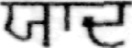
ਯਾਦ
